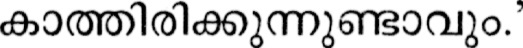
കാത്തിരിക്കുന്നുണ്ടാവും.’
